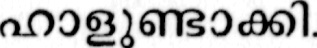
ഹാളുണ്ടാക്കി.
